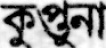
কুপ্তুনা
